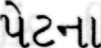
પેટના
